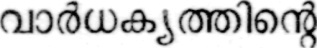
വാര്‍ധക്യത്തിന്റെ
